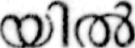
യില്‍
